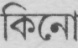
কিনো
